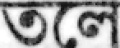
তলে
